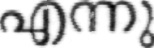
എന്നു
